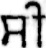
ਸੀ
